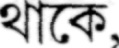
থাকে,
